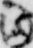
છે
